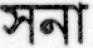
সনা
